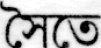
সৈতে
